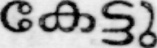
കേട്ടു
